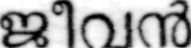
ജീവന്‍
